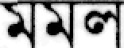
মমল
